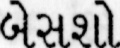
બેસશો
